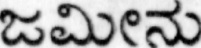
ಜಮೀನು
